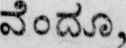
ವೆಂದೂ,
